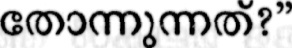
തോന്നുന്നത്?”
